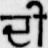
ਦੀ
